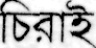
চিরাই
